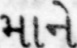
માને
